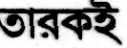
তারকই
